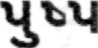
પુષ્પ
